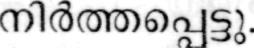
നിര്‍ത്തപ്പെട്ടു.
